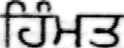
ਹਿੰਮਤ
